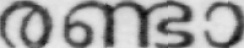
രണ്ടാ
